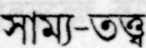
সাম্য-তত্ত্ব
